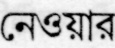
নেওয়ার
